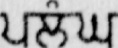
ਪਲੰਘ
